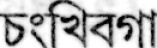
চংখিবগা
